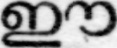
ഈ
